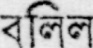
বলিল
